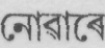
নোৱাৰে
